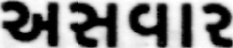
અસવાર
